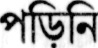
পড়িনি
